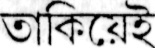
তাকিয়েই
